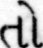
તો
